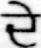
ਦੇ
